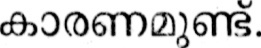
കാരണമുണ്ട്.
